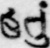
હતું
